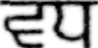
ਵਧ
